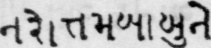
નરોત્તમબાબુને
